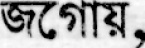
জগোয়,
